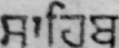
ਸਾਹਿਬ
